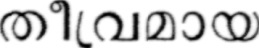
തീവ്രമായ
